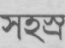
সহস্ৰ
